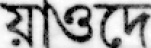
য়াওদে
